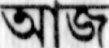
আজ
